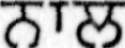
ਨਾਲ
